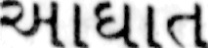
આઘાત
